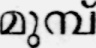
മുമ്പ്
